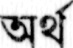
অর্থ
